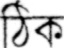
ঠিক
